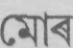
মোৰ
